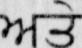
ਅਤੇ
